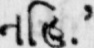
નહિ.'
